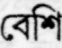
বেশি
